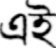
এই
